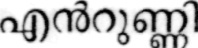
എന്റുണ്ണി
